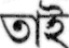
তাই
